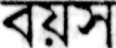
বয়স
